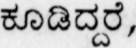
ಕೂಡಿದ್ದರೆ,
